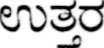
ಉತ್ತರ
